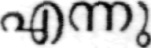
എന്നു
